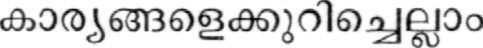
കാര്യങ്ങളെക്കുറിച്ചെല്ലാം
